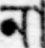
না
